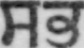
ਸਭ
